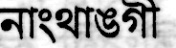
নোংথাঙগী
